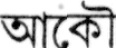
আকৌ
